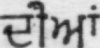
ਦੀਆਂ
